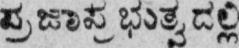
ಪ್ರಜಾಪ್ರಭುತ್ವದಲ್ಲಿ
